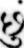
છું
